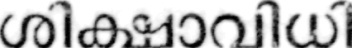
ശിക്ഷാവിധി
